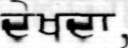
ਦੇਖਦਾ,
